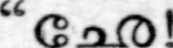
"ഛേ!
